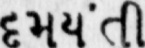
દમયંતી
